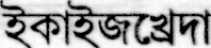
ইকাইজখ্রেদা
